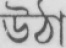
উঠা
